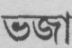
ভজা
